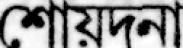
শোয়দনা
